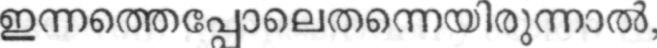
ഇന്നത്തെപ്പോലെതന്നെയിരുന്നാല്‍,
